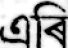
এৰি
